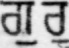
ਗੁਰੂ
